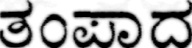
ತಂಪಾದ
